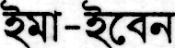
ইমা-ইবেন
